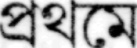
প্রথমে
